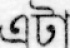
এটা
